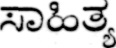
ಸಾಹಿತ್ಯ
